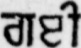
ਗਈ
